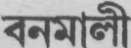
বনমালী
